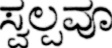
ಸ್ವಲ್ಪವೂ
